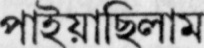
পাইয়াছিলাম
